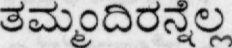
ತಮ್ಮಂದಿರನ್ನೆಲ್ಲ
